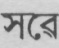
সৱে
